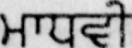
ਮਾਧਵੀ
